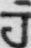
ਹੋ
